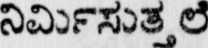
ನಿರ್ಮಿಸುತ್ತಲೆ
